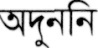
অদুননি
